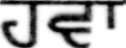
ਹਵਾ
